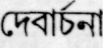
দেবার্চনা
